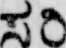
ಸರಿ
